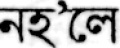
নহ'লে
